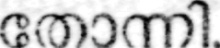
തോന്നി.
